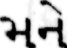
મને
